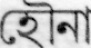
হৌনা
